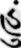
હું
